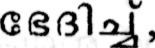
ഭേദിച്ച്,
